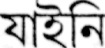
যাইনি
